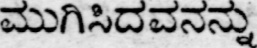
ಮುಗಿಸಿದವನನ್ನು
